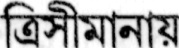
ত্রিসীমানায়
